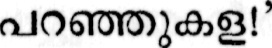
പറഞ്ഞുകള!'
